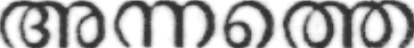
അന്നത്തെ
